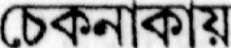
চেকনাকায়
